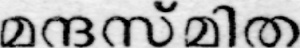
മന്ദസ്മിത
